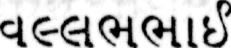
વલ્લભભાઈ
